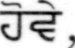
ਹੋਵੇ,
